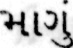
માગું
